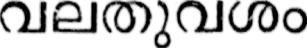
വലതുവശം
